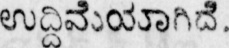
ಉದ್ದಿಮೆಯಾಗಿದೆ.
